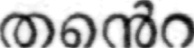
തന്റെ
